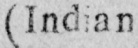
(Indian
